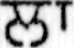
ਲਾ
